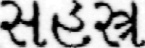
સહસ્ત્ર
